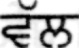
ਵੱਲ
